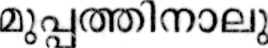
മുപ്പത്തിനാലു
